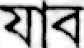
যাব
